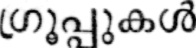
ഗ്രൂപ്പുകള്‍
